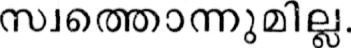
സ്വത്തൊന്നുമില്ല.
